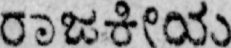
ರಾಜಕೀಯ
